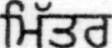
ਮਿੱਤਰ
